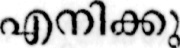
എനിക്കു
